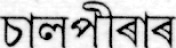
চালপীৰাৰ
